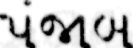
પંજાબ
